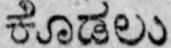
ಕೊಡಲು
